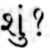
શું?
